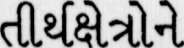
તીર્થક્ષેત્રોને
